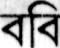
ববি
